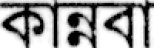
কান্নবা
